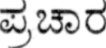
ಪ್ರಚಾರ
